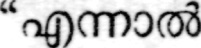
“എന്നാല്‍
